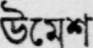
উমেশ
